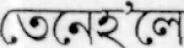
তেনেহ'লে
